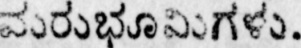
ಮರುಭೂಮಿಗಳು.
